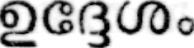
ഉദ്ദേശം
